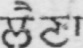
ਲੈਣਾ
